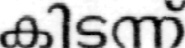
കിടന്ന്
